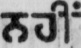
ਨਹੀਂ
